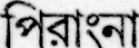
পিরাংনা
